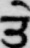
ਤੇ
